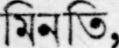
মিনতি,
